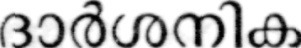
ദാര്‍ശനിക
